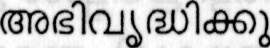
അഭിവൃദ്ധിക്കു
